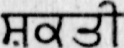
ਸ਼ਕਤੀ
